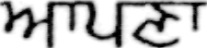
ਆਪਣਾ
